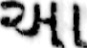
આ
